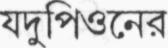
যদুপিওনের
